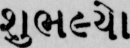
શુભલ્યો
